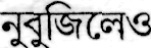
নুবুজিলেও
